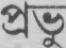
প্ৰভু
